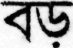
বড়
